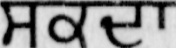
ਸਕਦਾ
